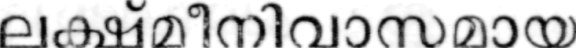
ലക്ഷ്മീനിവാസമായ
